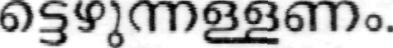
ട്ടെഴുന്നള്ളണം.
